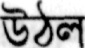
উঠল
